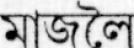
মাজলৈ
